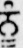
ਨੂੰ
